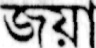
জয়া
